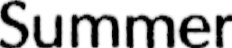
Summer
